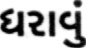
ધરાવું
